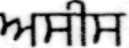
ਅਸੀਸ
